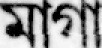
মাগা
